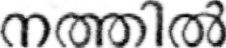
നത്തില്‍
